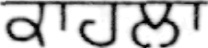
ਕਾਹਲਾ
